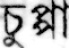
চুপ্পা
